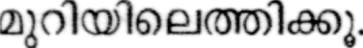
മുറിയിലെത്തിക്കൂ.
